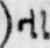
ના
